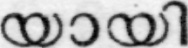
യായി
